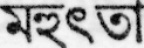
মহুৎতা
